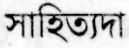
সাহিত্যদা
